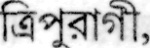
ত্রিপুরাগী,
